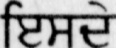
ਇਸਦੇ
